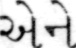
એને
